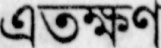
এতক্ষণ
